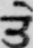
ਤੇ
